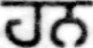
ਹਨ
